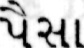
પૈસા
